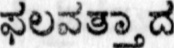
ಫಲವತ್ತಾದ
